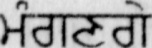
ਮੰਗਣਗੇ
